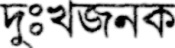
দুঃখজনক
